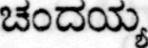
ಚಂದಯ್ಯ
